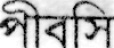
পীবসি
